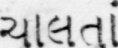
ચાલતાં
